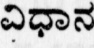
ವಿಧಾನ
